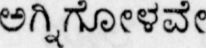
ಅಗ್ನಿಗೋಳವೇ
